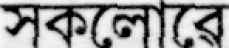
সকলোৱে
